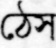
ঠেস
